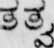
ತತ್ವ
